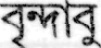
বৃন্দাবু
